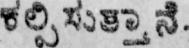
ಕಲ್ಪಿಸುತ್ತಾನೆ.
